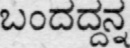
ಬಂದದ್ದನ್ನ
